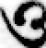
ও
